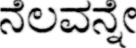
ನೆಲವನ್ನೇ
